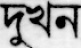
দুখন
